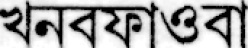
খনবফাওবা
